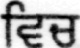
ਵਿਚ
